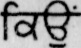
ਕਿਉਂ
